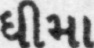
ધીમા
